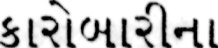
કારોબારીના
